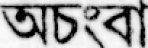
অচংবা
